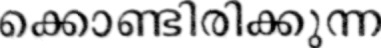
ക്കൊണ്ടിരിക്കുന്ന
